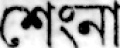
শেংনা
